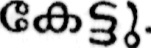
കേട്ടു.
